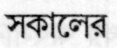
সকালের
